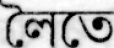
লৈতে
